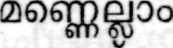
മണ്ണെല്ലാം
